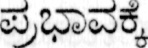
ಪ್ರಭಾವಕ್ಕೆ
